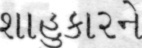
શાહુકારને
